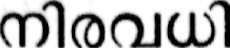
നിരവധി
